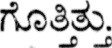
ಗೊತ್ತಿತ್ತು.
